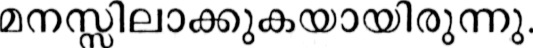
മനസ്സിലാക്കുകയായിരുന്നു.
